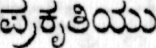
ಪ್ರಕೃತಿಯು
